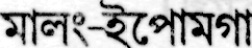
মালং-ইপোমগা
